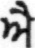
ਐ
